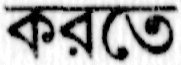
করতে
